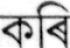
কৰি
